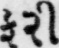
ફરી
